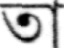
তা
